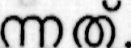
ന്നത്.
